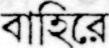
বাহিরে
